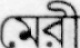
মেরী
